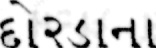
દોરડાના
